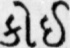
કોઈ
